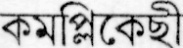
কমপ্লিকেছী
